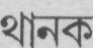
থানক
